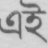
এই
